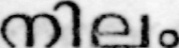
നിലം
